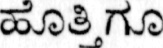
ಹೊತ್ತಿಗೂ
